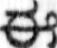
ಈ
